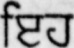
ਇਹ
